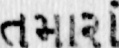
તમારાં
